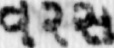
વરસ
